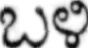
ಬಳಿ
